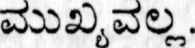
ಮುಖ್ಯವಲ್ಲ.
